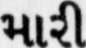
મારી
